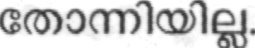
തോന്നിയില്ല.
